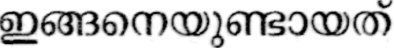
ഇങ്ങനെയുണ്ടായത്
